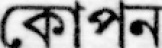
কোপন
